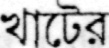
খাটের
